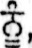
ਨੂੰ,
